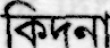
কিদনা
